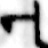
ન
